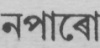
নপাৰো
